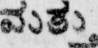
ಮತ್ತು
